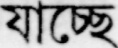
যাচ্ছে
